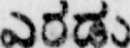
ಎರಡು
